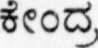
ಕೇಂದ್ರ
